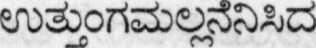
ಉತ್ತುಂಗಮಲ್ಲನೆನಿಸಿದ
